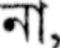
না,
